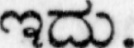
ಇದು.
